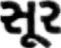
સૂર
